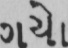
ગયો
